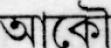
আকৌ
